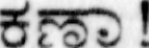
ಕಣಾ!
